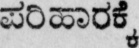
ಪರಿಹಾರಕ್ಕೆ
